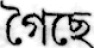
গৈছে
